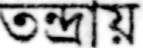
তন্দ্রায়
